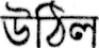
উঠিল
